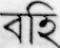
বহি
